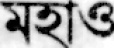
মহাও
